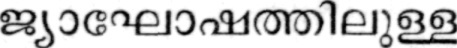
ജ്യാഘോഷത്തിലുള്ള
